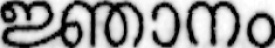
ജ്ഞാനം
